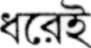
ধরেই
